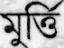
মুর্ত্তি
